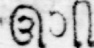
ઊગી
